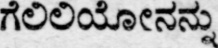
ಗೆಲಿಲಿಯೋನನ್ನು
